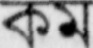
কম
